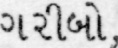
ગરીબો,
